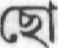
ছো
